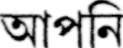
আপনি
